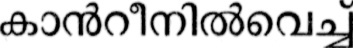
കാന്റീനില്‍വെച്ച്
